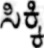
ಸಿಕ್ಕಿ
